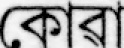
কোৱা
